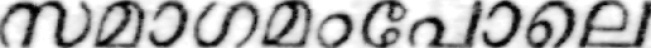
സമാഗമംപോലെ
